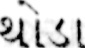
થોડા
